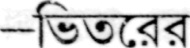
-ভিতরের
